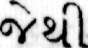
જેથી
